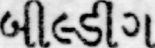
બીલ્ડીંગ
